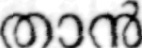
താന്‍
